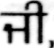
ਜੀ,
